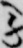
કે
